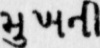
મુખની
